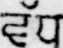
ਵੱਧ
